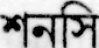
শনসি
